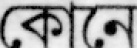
কোনে
